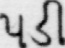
પડી
